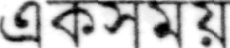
একসময়
